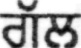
ਗੱਲ
